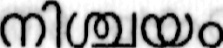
നിശ്ചയം
